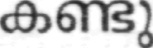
കണ്ടു
